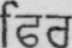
ਫਿਰ
